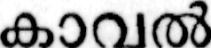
കാവല്‍
